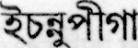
ইচন্নুপীগা
